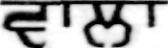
ਵਾਲਾ
